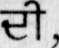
ਦੀ,
